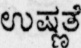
ಉಷ್ಣತೆ
